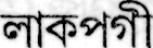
লাকপগী
